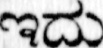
ಇದು
